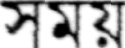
সময়
